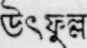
উৎফুল্ল
